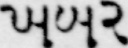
ખબર
